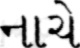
નાચે
